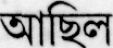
আছিল
